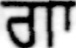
ਗਾ
